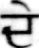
ਦੇ
